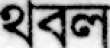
থবল
